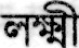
লক্ষ্মী
